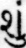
શું
